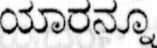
ಯಾರನ್ನೂ
